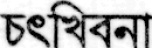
চৎখিবনা
